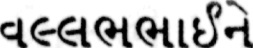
વલ્લભભાઈને
